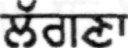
ਲੱਗਣਾ
